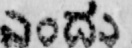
ಎ೦ದು
